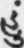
હું
